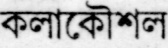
কলাকৌশল
